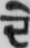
ਦੇ
